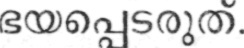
ഭയപ്പെടരുത്.
